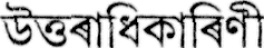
উত্তৰাধিকাৰিণী
